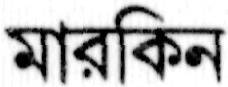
মারকিন
